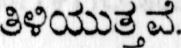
ತಿಳಿಯುತ್ತವೆ.
